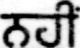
ਨਹੀਂ
